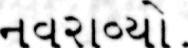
નવરાવ્યો.
